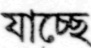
যাচ্ছে
